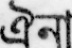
ঐনা
